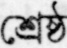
শ্রেষ্ঠ
